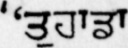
''ਤੁਹਾਡਾ
